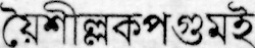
য়ৈশীল্লকপগুমই
